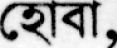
হোবা,
